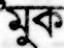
’মুক
